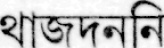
থাজদননি
